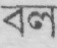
বল
